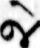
જે
